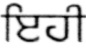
ਇਹੀ
